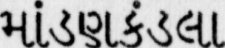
માંડણકંડલા
